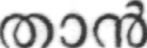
താന്‍
